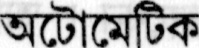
অটোমেটিক
